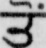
ਤੋਂ
